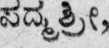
ಪದ್ಮಶ್ರೀ,
